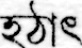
হঠাৎ
